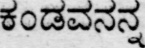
ಕಂಡವನನ್ನ
